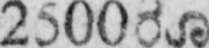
2500ರೂ
